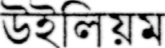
উইলিয়ম
